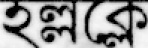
হল্লক্লে
